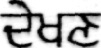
ਦੇਖਣ
